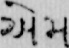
એમ
